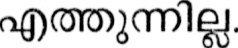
എത്തുന്നില്ല.
